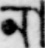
না
